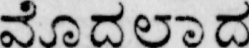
ಮೊದಲಾದ
